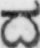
ದ
